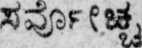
ಸರ್ವೋಚ್ಚ
